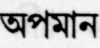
অপমান
